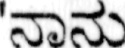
‘ನಾನು
